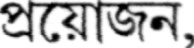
প্রয়োজন,
